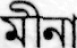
মীনা
